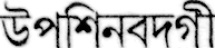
উপশিনবদগী
